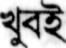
খুবই
